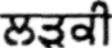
ਲੜਕੀ
